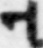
ન
